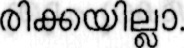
രിക്കയില്ലാ.
